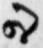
જે
